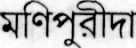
মণিপুরীদা
